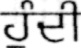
ਹੁੰਦੀ
